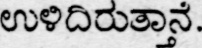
ಉಳಿದಿರುತ್ತಾನೆ.
